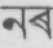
নৰ
